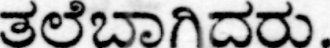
ತಲೆಬಾಗಿದರು.
